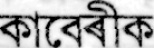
কাবেৰীক
